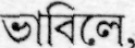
ভাবিলে,
